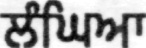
ਲੰਘਿਆ
